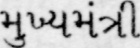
મુખ્યમંત્રી
